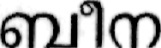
ബീന
